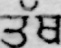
ਤੱਥ
